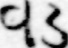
વડ
